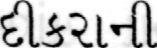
દીકરાની
